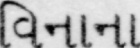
વિનાના
